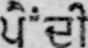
ਪੈਂਦੀ
